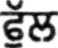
ਫੁੱਲ
